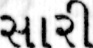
સારી
